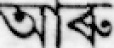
আৰু
